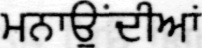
ਮਨਾਉਂਦੀਆਂ
